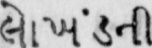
લોખંડની
